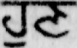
ਹੁਣ
